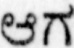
ಆಗ
